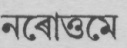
নৰোত্তমে
